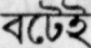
বটেই
